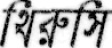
থিরুসি
